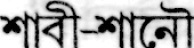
শাবী-শানৌ
